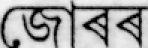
জোৰৰ
